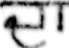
ਦਾ
